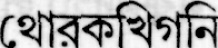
থোরকখিগনি
